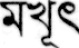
মখূৎ
